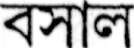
বসাল
